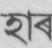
হাৰ
